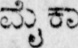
ಮೈಕಾ
